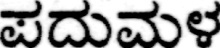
ಪದುಮಳ
